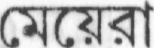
মেয়েরা
